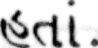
હતાં.
